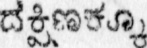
ದಕ್ಷಿಣಕ್ಕೂ
